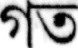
গত
